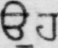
ਉਹ
